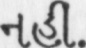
નહીં.
